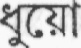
ধুয়ো
